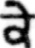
ਕੇ
